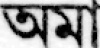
অমা
